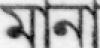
মানা
